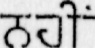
ਨਹੀਂ
